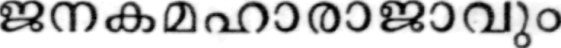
ജനകമഹാരാജാവും
